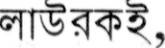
লাউরকই,
